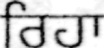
ਰਿਹਾ
